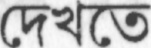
দেখতে
